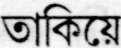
তাকিয়ে
